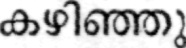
കഴിഞ്ഞു
